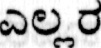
ಎಲ್ಲರ
